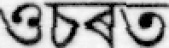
ওচৰত
